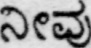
ನೀವು
